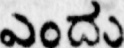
ಎಂದು
